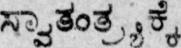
ಸ್ವಾತಂತ್ರ್ಯಕ್ಕೆ
